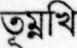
তূম্নখি
